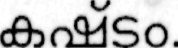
കഷ്ടം
